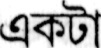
একটা
